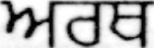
ਅਰਥ
